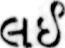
લઈ
